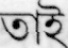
তাই
